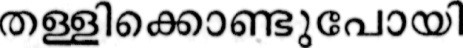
തള്ളിക്കൊണ്ടുപോയി
